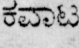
ಕವಾಟ
